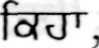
ਕਿਹਾ,
